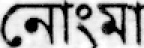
নোংমা
